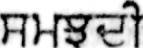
ਸਮਝਦੀ
